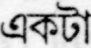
একটা
